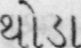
થોડા
